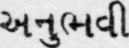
અનુભવી
